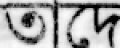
তাদে
